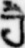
ਹੈ
